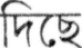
দিছে
